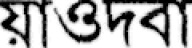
য়াওদবা
